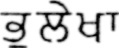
ਭੁਲੇਖਾ
